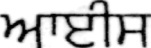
ਆਈਸ
